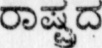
ರಾಷ್ಟ್ರದ
